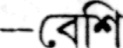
-বেশি
